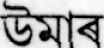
উমাৰ
